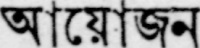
আয়োজন
